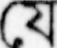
যে
